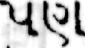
પણ
